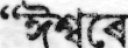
"ঈশ্বৰে
